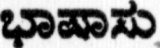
ಭಾಷಾಸು
